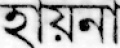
হায়না
